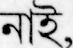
নাই,
